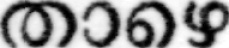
താഴെ
